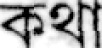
কথা
